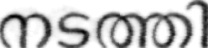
നടത്തി
